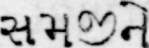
સમજીને
